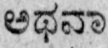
ಅಥವಾ
